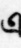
এ
